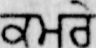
ਕਮਰੇ
